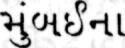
મુંબઈના
